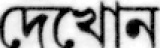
দেখোন
